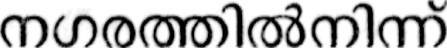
നഗരത്തില്‍നിന്ന്
